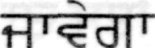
ਜਾਵੇਗਾ
